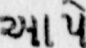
આપે
